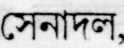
সেনাদল,
